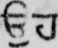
ਉਹ
